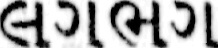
લગભગ
